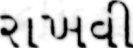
રાખવી
